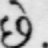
છે.
